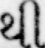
થી
